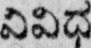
ವಿವಿಧ
